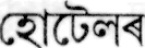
হোটেলৰ
